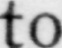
to
